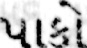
પાકો
